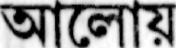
আলোয়
